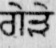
ਗੇੜੇ
